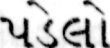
પડેલો
